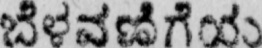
ಬೆಳವಣಿಗೆಯ
